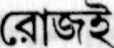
রোজই
